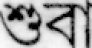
শুবা
